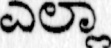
ಎಲ್ಲಾ
